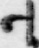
ન
